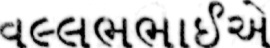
વલ્લભભાઈએ
